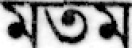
মতম
